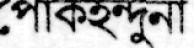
পোকহন্দুনা
